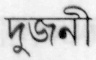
দুজনী
